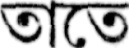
তাতে
